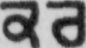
ਕਰ
